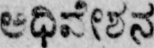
ಅಧಿವೇಶನ
